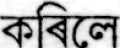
কৰিলে
